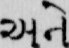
અને
